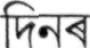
দিনৰ
